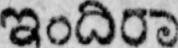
ಇಂದಿರಾ
